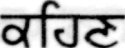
ਕਹਿਣ
